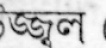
উজ্জ্বল
